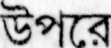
উপরে
